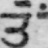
ਤੋਂ
